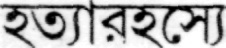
হত্যারহস্যে
